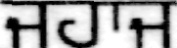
ਜਹਾਜ
